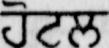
ਹੋਟਲ
